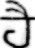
ਹੈ
